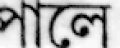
পালে
